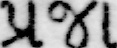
પ્રજા
